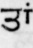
ਤਾਂ
